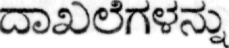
ದಾಖಲೆಗಳನ್ನು
